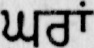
ਘਰਾਂ
